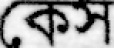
কেস
